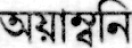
অয়াম্বনি
